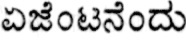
ಏಜೆಂಟನೆಂದು
